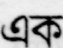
এক
